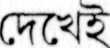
দেখেই
